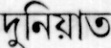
দুনিয়াত
